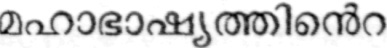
മഹാഭാഷ്യത്തിന്റെ
